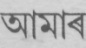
আমাৰ
